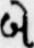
બે
